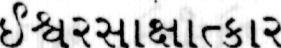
ઈશ્વરસાક્ષાત્કાર
